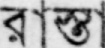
রাস্তা
